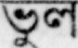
ভুল
